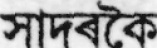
সাদৰকৈ
